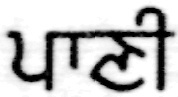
ਪਾਣੀ
